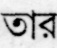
তার
